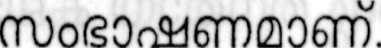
സംഭാഷണമാണ്.
